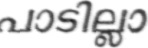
പാടില്ലാ
